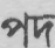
পদ
